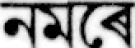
নমৰে
